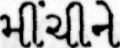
મીંચીને
